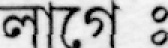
লাগেঃ
